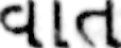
વાત
